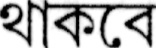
থাকবে
